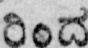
ರಿಂದ
